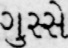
ગુસ્સે
